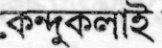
কেন্দুকলাই
